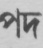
পদ
